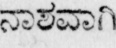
ನಾಶವಾಗಿ
